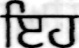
ਇਹ
